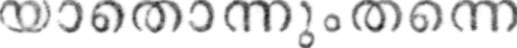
യാതൊന്നുംതന്നെ
